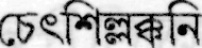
চেৎশিল্লক্কনি
